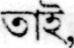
তাই,
